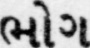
ભોગ
